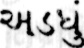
અડધું
